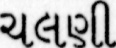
ચલણી
